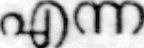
എന്ന
